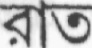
রাত
